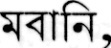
মবানি,
